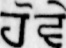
ਹੋਵੇ
